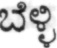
ಬೆಳ್ಳಿ
